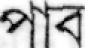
পাব
